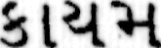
કાયમ
